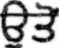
ਉਤੋਂ
